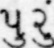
પુરું
